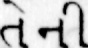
તેની
